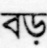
বড়
